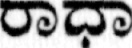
ರಾಧಾ
